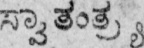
ಸ್ವಾತಂತ್ರ್ಯ
